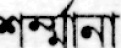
শর্ম্মানা
